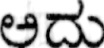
ಅದು
